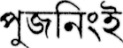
পুজনিংই
